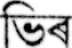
ভিৰ
